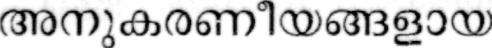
അനുകരണീയങ്ങളായ
